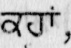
ਕਹਾਂ,
